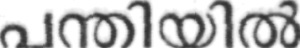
പന്തിയില്‍
